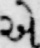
એ
